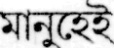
মানুহেই
